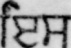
ਇਸ
